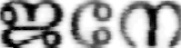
ജനേ
